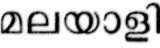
മലയാളി
